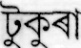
টুকুৰা
